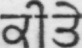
ਕੀਤੇ
